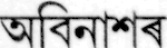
অবিনাশৰ
